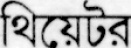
থিয়েটর
